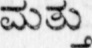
ಮತ್ತು
